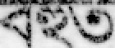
বহুত
